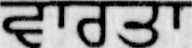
ਵਾਰਤਾ
